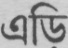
এড়ি
